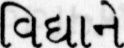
વિદ્યાને
